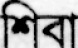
শিবা
